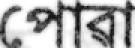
পোৱা
